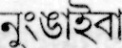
নুংঙাইবা
